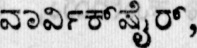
ವಾರ್ವಿಕ್ಷೈರ್,
